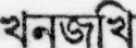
খনজখি
